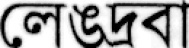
লেঙদ্রবা
